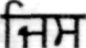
ਜਿਸ
